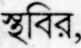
স্থবির,
